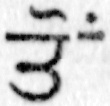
ਤੋਂ
